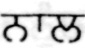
ਨਾਲ
